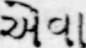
એવા
